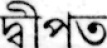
দ্বীপত
